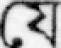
যে
